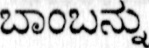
ಬಾಂಬನ್ನು
